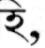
হি,
